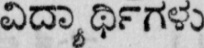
ವಿದ್ಯಾರ್ಥಿಗಳು
